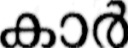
കാര്‍
